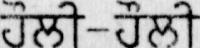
ਹੌਲੀ-ਹੌਲੀ
